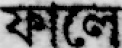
ফালে
